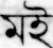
মই
